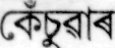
কেঁচুৱাৰ
